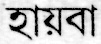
হায়বা
